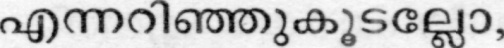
എന്നറിഞ്ഞുകൂടല്ലോ,
